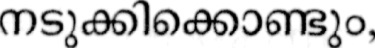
നടുക്കിക്കൊണ്ടും,
